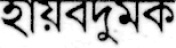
হায়বদুমক
